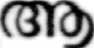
ആ
